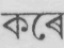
কৰে
